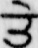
ਤੇ
